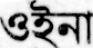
ওইনা
